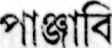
পাঞ্জাবি
